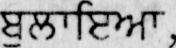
ਬੁਲਾਇਆ,
